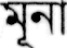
মূনা
